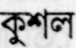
কুশল
